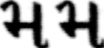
મમ
